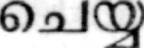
ചെയ്യ
